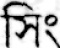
সিং
